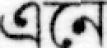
এনে
